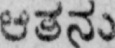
ಆತನು
